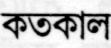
কতকাল
